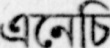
এনেচি
